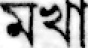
মখা
